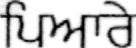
ਪਿਆਰੇ
